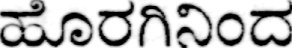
ಹೊರಗಿನಿಂದ
